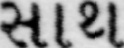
સાથ
